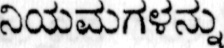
ನಿಯಮಗಳನ್ನು
